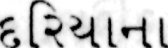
દરિયાના
